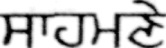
ਸਾਹਮਣੇ
